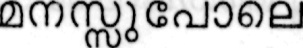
മനസ്സുപോലെ
